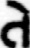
તે
